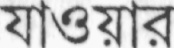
যাওয়ার
